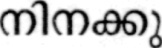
നിനക്കു
